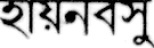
হায়নবসু
